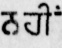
ਨਹੀਂ
